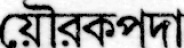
য়ৌরকপদা
